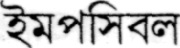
ইমপসিবল
